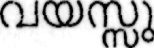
വയസ്സു
